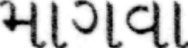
માગવા
